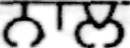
ਨਾਲ
